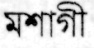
মশাগী
